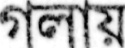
গলায়
